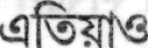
এতিয়াও
